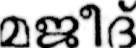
മജീദ്
